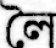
লৈ
